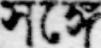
সঙ্গে
